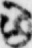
છે
